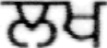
ਲਖ
